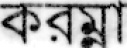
করম্না
